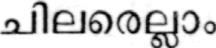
ചിലരെല്ലാം
